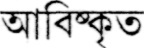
আবিষ্কৃত
